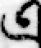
এ
